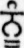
ਨੂੰ
